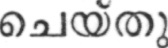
ചെയ്തു
